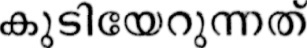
കുടിയേറുന്നത്
